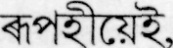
ৰূপহীয়েই,
